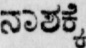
ನಾಶಕ್ಕೆ
